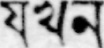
যখন
